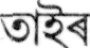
তাইৰ
